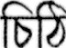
চিঠি
